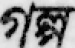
গল্প
